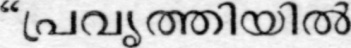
"പ്രവൃത്തിയില്‍
